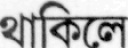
থাকিলে
